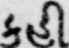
કહી
